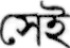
সেই
